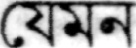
যেমন
